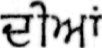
ਦੀਆਂ
